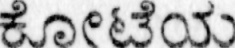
ಕೋಟೆಯ
